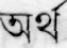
অর্থ
